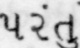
પરંતું
